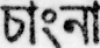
চাংনা
